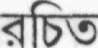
রচিত
